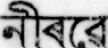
নীৰৱে
